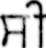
ਸੀ
